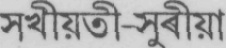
সখীয়তী-সুৰীয়া
